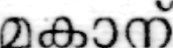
മകാന്
